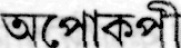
অপোকপী
